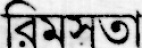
রিমসতা
